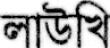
লাউখি
